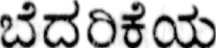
ಬೆದರಿಕೆಯ
